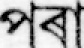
পৰা
